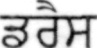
ਡਰੈਸ
